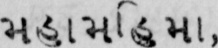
મહામહિમા,
